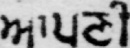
ਆਪਣੀ
